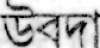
উবদা
